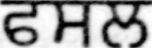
ਫਸਲ
